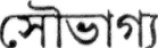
সৌভাগ্য
